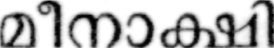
മീനാക്ഷി
